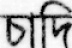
চাদি
